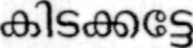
കിടക്കട്ടേ
